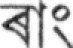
ৰাং
